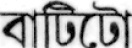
বাটিটো
